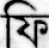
ফি
